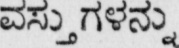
ವಸ್ತುಗಳನ್ನು
